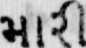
મારી
